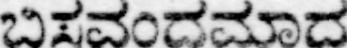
ಬಿಸವಂದಮಾದ
